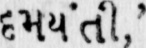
દમયંતી,'
